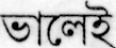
ভালেই
